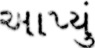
આપ્યું
